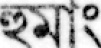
হুমাং
